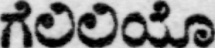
ಗೆಲಿಲಿಯೊ
